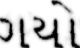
ગયો
